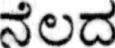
ನೆಲದ
